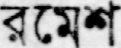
রমেশ
